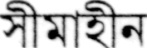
সীমাহীন
